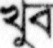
খুব
